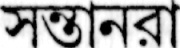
সন্তানরা
